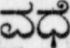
ವಧೆ
